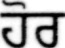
ਹੋਰ
